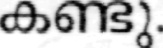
കണ്ടു.
